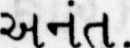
અનંત.
